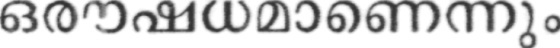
ഒരൗഷധമാണെന്നും
